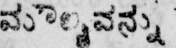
ಮೌಲ್ಯವನ್ನು
